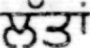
ਲੱਤਾਂ
